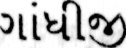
ગાંધીજી
